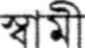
স্বামী
